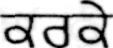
ਕਰਕੇ
